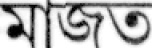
মাজত
